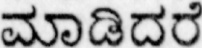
ಮಾಡಿದರೆ
